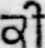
ਕੀ
